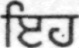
ਇਹ
